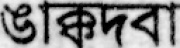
ঙাক্কদবা
